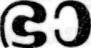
ഭാ
